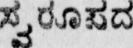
ಸ್ವರೂಪದ
